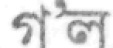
গ'ল
